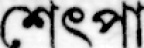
শেৎপা
